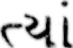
ત્યાં
